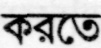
করতে
